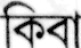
কিবা
